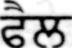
ਫੈਲ
